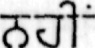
ਨਹੀਂ
